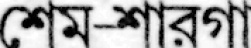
শেম-শারগা
